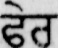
ਫੇਰ
